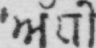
'ਅੱਧੀ
